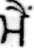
ਮੈਂ
